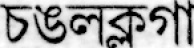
চঙলক্লগা
